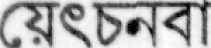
য়েৎচনবা
